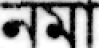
নমা
